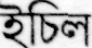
ইচিন
